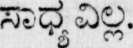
ಸಾಧ್ಯವಿಲ್ಲ.
